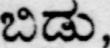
ಬಿಡು,
